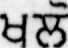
ਖਲੋ
